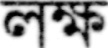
লক্ষ
